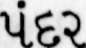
પંદર
